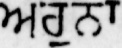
ਅਰੁਨਾ
